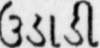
ઉડાડી
